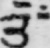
ਤੋਂ
